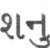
શનુ
